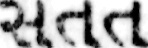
સતત
